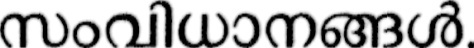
സംവിധാനങ്ങള്‍.
